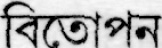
বিতোপন
